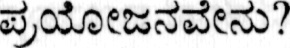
ಪ್ರಯೋಜನವೇನು?
